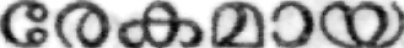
രേകമായ
